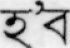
হ'ব
